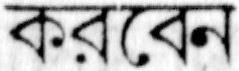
করবেন
